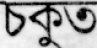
চকুত
